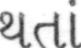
થતાં
